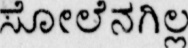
ಸೋಲೆನಗಿಲ್ಲ
